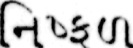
નિષ્ફળ
